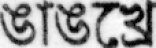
ঙাঙখ্রে
